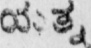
ಯತ್ನ
